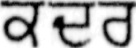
ਕਦਰ
